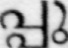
പ്പു
